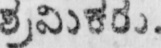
ಶ್ರಮಿಕರು.
